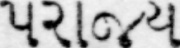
પરાજ્ય
